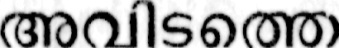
അവിടത്തെ
